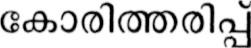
കോരിത്തരിപ്പ്
